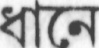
ধানে
